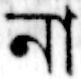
না
